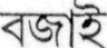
বজাই
